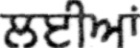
ਲਈਆਂ
